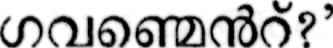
ഗവണ്മെൻറ്?'
